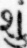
શું
